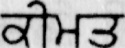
ਕੀਮਤ
